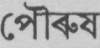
পৌৰুষ
